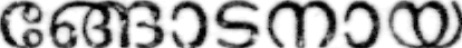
ങ്ങോടനായ
